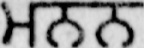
ਮਨਨ
